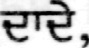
ਦਾਦੇ,
